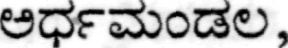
ಅರ್ಧಮಂಡಲ,
